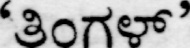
‘ತಿಂಗಳ್’
